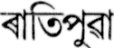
ৰাতিপুৱা
